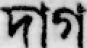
দাগ
